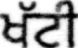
ਖੱਟੀ
